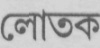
লোতক
